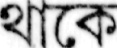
থাকে
